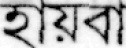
হায়বা
